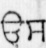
ਉਸ
